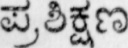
ಪ್ರಶಿಕ್ಷಣ
